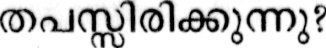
തപസ്സിരിക്കുന്നു?
